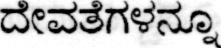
ದೇವತೆಗಳನ್ನೂ
